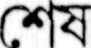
শেষ
